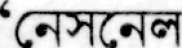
‘নেসনেল
